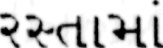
રસ્તામાં
